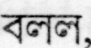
বলল,
